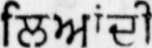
ਲਿਆਂਦੀ
